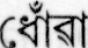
ধোঁৱা
